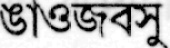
ঙাওজবসু
